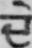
ਦੇ
